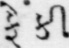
ફેંકી
